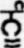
ਨੂੰ
